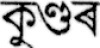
কুণ্ডৰ
